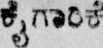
ಕೃಗಾರಿಕೆ
